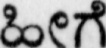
ಹೀಗೆ
